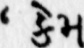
'કેમ
